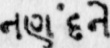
નણંદને
